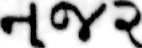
નજર
